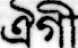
ঐগী
